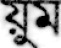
য়ুম
